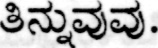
ತಿನ್ನುವುವು.
